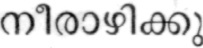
നീരാഴിക്കു
